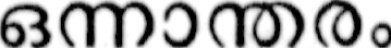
ഒന്നാന്തരം
